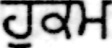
ਹੁਕਮ
